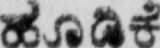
ಹೂಡಿಕೆ
